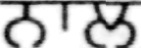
ਨਾਲ
